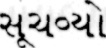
સૂચવ્યો
